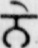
ਨੇ
